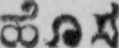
ಹೊಸ
